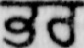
ਭਰ
